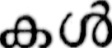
കള്‍
